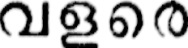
വളരെ
